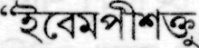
“ইবেমপীশক্তু
